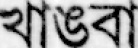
খাঙবা
